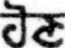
ਹੋਣ
